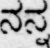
ನನ್ನ
